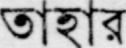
তাহার
